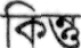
কিন্তু
